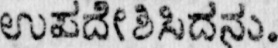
ಉಪದೇಶಿಸಿದನು.
